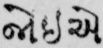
જોઈએ
